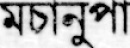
মচানুপা
